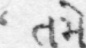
'તમે
